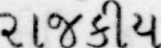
રાજકીય
